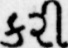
કરી
